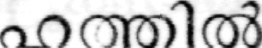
ഹത്തില്‍
